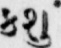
કશું
